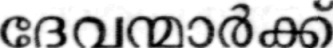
ദേവന്മാര്‍ക്ക്
